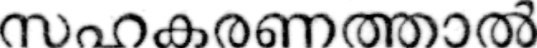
സഹകരണത്താല്‍
